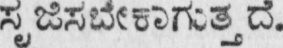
ಸೃಜಿಸಬೇಕಾಗುತ್ತದೆ.
